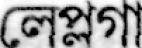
লেপ্লগা
